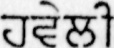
ਹਵੇਲੀ
